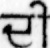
ਦੀ
